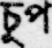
চুপ
